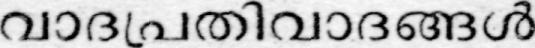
വാദപ്രതിവാദങ്ങള്‍
